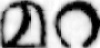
മറ
